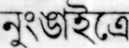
নুংঙাইত্রে
